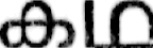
കഥ
